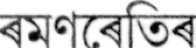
ৰমণৰেতিৰ
